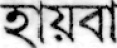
হায়বা
